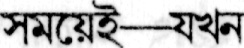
সময়েই–যখন
